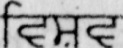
ਵਿਸ਼ਵ
